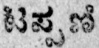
ಟಿಪ್ಪಣಿ
